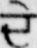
ਦੇ
